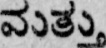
ಮತ್ತು
